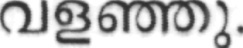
വളഞ്ഞു.
